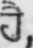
ਹੈ,
